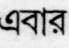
এবার
